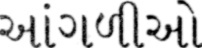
આંગળીઓ
